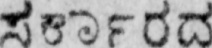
ಸರ್ಕಾರದ
